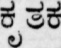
ಕೃತಕ
